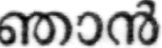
ഞാന്‍
